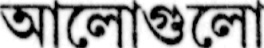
আলোগুলো
